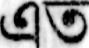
এত
